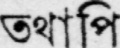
তথাপি
